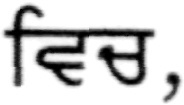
ਵਿਚ,
